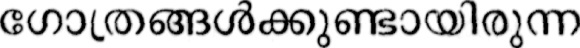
ഗോത്രങ്ങള്‍ക്കുണ്ടായിരുന്ന
